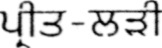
ਪ੍ਰੀਤ-ਲੜੀ
